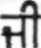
ਜੀ
